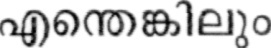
എന്തെങ്കിലും
